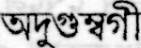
অদুগুম্বগী
